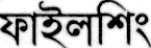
ফাইলশিং
